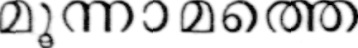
മൂന്നാമത്തെ
